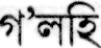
গ'লহি
